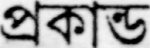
প্রকান্ড
